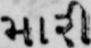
મારી
